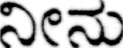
ನೀನು
